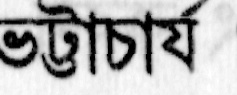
ভট্টাচার্য
